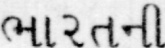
ભારતની
